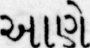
આણે
